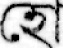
হো
